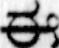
ಈ
